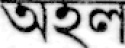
অহল
